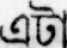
এটা
